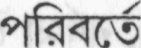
পরিবর্তে
